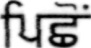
ਪਿਛੋਂ
